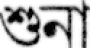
শুনা
